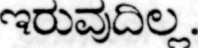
ಇರುವುದಿಲ್ಲ.
